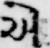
એ
